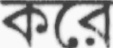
করে
